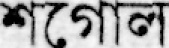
শগোল
